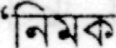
‘নিমক
